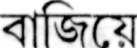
বাজিয়ে
